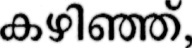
കഴിഞ്ഞ്,
